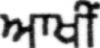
ਆਖੀਂ
